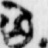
છે.
